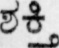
ಶಕ್ತಿ
